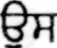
ਉਸ
